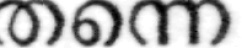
തന്നെ
